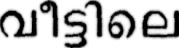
വീട്ടിലെ
